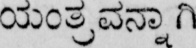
ಯಂತ್ರವನ್ನಾಗಿ
